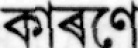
কাৰণে
